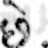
છે.
